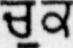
ਚੁਕ
